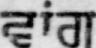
ਵਾਂਗ
